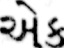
એક
